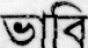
ভাবি
